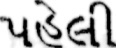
પહેલી
